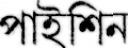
পাইশিন
